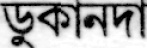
ডুকানদা
